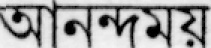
আনন্দময়
